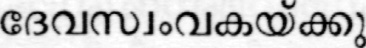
ദേവസ്വംവകയ്ക്കു
